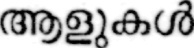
ആളുകള്‍
